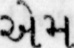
એમ
